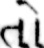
તો
